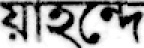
য়াহন্দে
